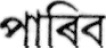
পাৰিব
